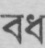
বধ
